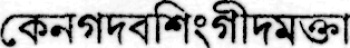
কেনগদবশিংগীদমক্তা
